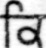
ਕਿ
